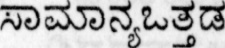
ಸಾಮಾನ್ಯಒತ್ತಡ
